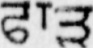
ਫਾੜ
